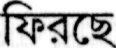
ফিরছে
